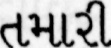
તમારી
